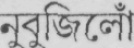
নুবুজিলোঁ
